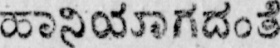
ಹಾನಿಯಾಗದಂತೆ
